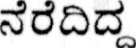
ನೆರೆದಿದ್ದ
